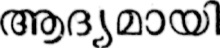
ആദ്യമായി
